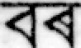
বৰ
